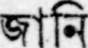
জানি
